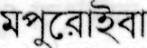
মপুরোইবা
